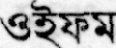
ওইফম
